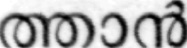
ത്താന്‍
